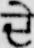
ਦੇ
